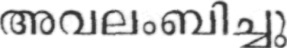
അവലംബിച്ചു
